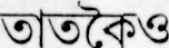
তাতকৈও
